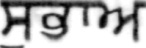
ਸੁਭਾਅ
